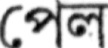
পেল
